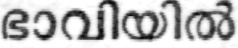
ഭാവിയില്‍
